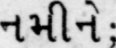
નમીને;
